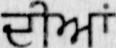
ਦੀਆਂ
